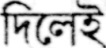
দিলেই
